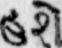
હશે
